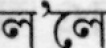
ল'লে
